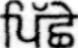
ਪਿੱਛੇ
